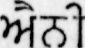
ਐਨੀ
